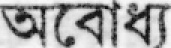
অবোধ্য
